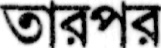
তারপর
